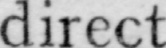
direct
